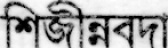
শিজীন্নবদা
